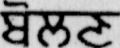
ਬੋਲਣ
